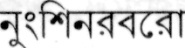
নুংশিনরবরো
